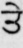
ਤੇ
